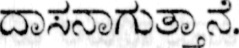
ದಾಸನಾಗುತ್ತಾನೆ.
